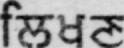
ਲਿਖਣ
